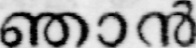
ഞാന്‍
